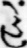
હેં
